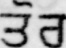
ਤੋਰ
